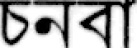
চনবা
